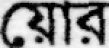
য়োর
